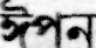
ঈপন
